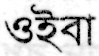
ওইবা
